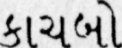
કાચબો
